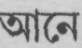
আনে
